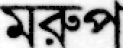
মরুপ
